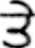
ਤੇ
